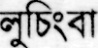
লুচিংবা
